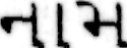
નામ
